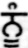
ਨੂੰ
